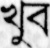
খুব
